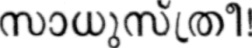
സാധുസ്ത്രീ!
